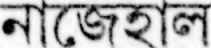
নাজেহাল
